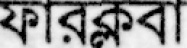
ফারক্লবা
